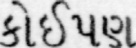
કોઈપણ
